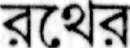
রথের
